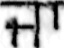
ਜਾਂ
